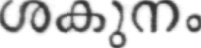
ശകുനം
